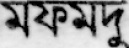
মফমদু
